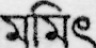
মমিৎ
